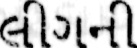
લીગની
